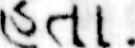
હતા.
